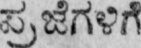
ಪ್ರಜೆಗಳಿಗೆ
